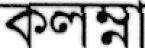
কলম্না
